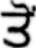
ਤੋਂ
